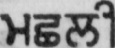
ਮਛਲੀ
